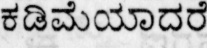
ಕಡಿಮೆಯಾದರೆ
